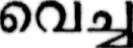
വെച്ച
